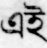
এই
